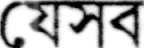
যেসব
